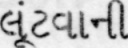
લૂંટવાની
